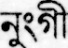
নুংগী
